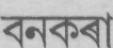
বনকৰা
